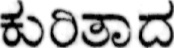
ಕುರಿತಾದ
